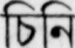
চিনি
